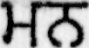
ਮਨ
